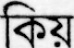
কিয়
